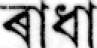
ৰাধা
